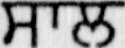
ਸਾਲ
